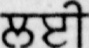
ਲਈ
